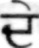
ਦੇ
